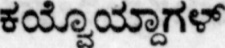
ಕಯ್ವೊಯ್ದಾಗಳ್
